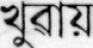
খুৱায়
